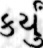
કર્યું
